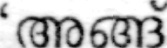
'അങ്ങ്
